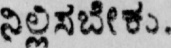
ನಿಲ್ಲಿಸಬೇಕು.
